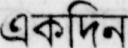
একদিন
